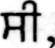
ਸੀ,
